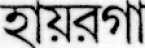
হায়রগা
